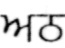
ਅਠ
